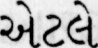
એટલે
